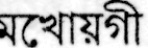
মখোয়গী
